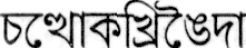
চত্থোকখ্রিঙৈদা
